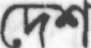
দেশ
